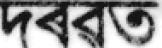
দৰৱত
